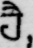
ਹੈ,
